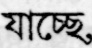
যাচ্ছে,
